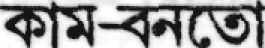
কাম-বনতো
